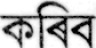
কৰিব
